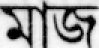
মাজ
